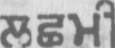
ਲਛਮੀ
